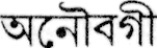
অনৌবগী
